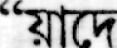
“য়াদে
